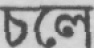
চলে
